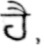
ਹੈ,
